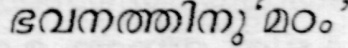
ഭവനത്തിനു'മഠം'
